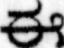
ಈ
